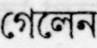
গেলেন
